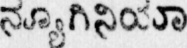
ನ್ಯೂಗಿನಿಯಾ
